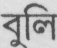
বুলি
